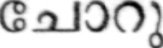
ചോറു
